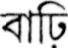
বাঢ়ি
